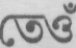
তেওঁ
